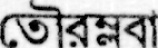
তৌরম্লবা
